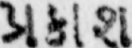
પ્રકાશ
